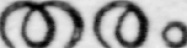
തരം
